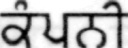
ਕੰਪਨੀ
